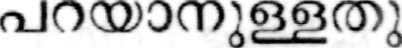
പറയാനുള്ളതു
